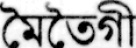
মৈতৈগী
